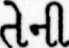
તેની
